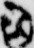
છે
